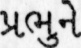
પ્રભુને
